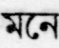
মনে
